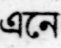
এনে
